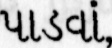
પાડવાં,
